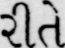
રીતે
